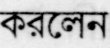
করলেন
